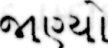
જાણ્યો
